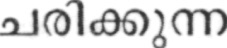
ചരിക്കുന്ന
